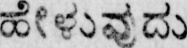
ಹೇಳುವುದು
